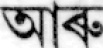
আৰু
